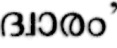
ദ്വാരം'
